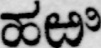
ಹಱಿ
